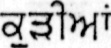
ਕੁੜੀਆਂ
